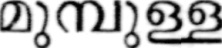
മുമ്പുള്ള
